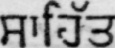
ਸਾਹਿੱਤ
